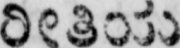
ರೀತಿಯ
